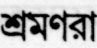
শ্রমণরা
